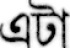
এটা
